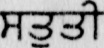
ਸਤੁਤੀ
